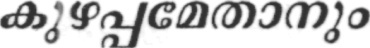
കുഴപ്പമേതാനും
